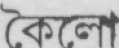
কৈলো
